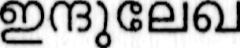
ഇന്ദുലേഖ
